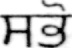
ਸਭੋ
